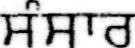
ਸੰਸਾਰ
